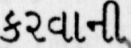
કરવાની
